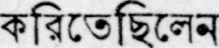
করিতেছিলেন
